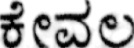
ಕೇವಲ
